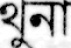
থুনা
